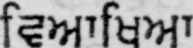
ਵਿਆਖਿਆ
